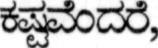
ಕಷ್ಟವೆಂದರೆ,
